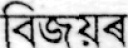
বিজয়ৰ
